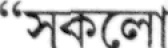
"সকলো
